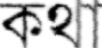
কথা
